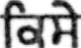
ਕਿਸੇ
